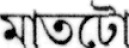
মাতটো
